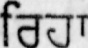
ਰਿਹਾ
